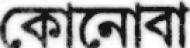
কোনোবা
